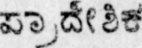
ಪ್ರಾದೇಶಿಕ
